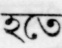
হতে
